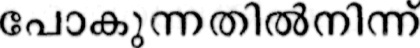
പോകുന്നതില്‍നിന്ന്
